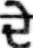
ਦੇ
